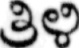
ತಿಳಿ
